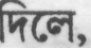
দিলে,
